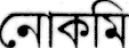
নোকমি
